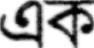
এক
